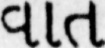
વાત
